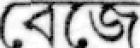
বেজে
